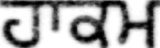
ਹਾਕਮ
